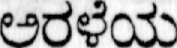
ಅರಳೆಯ
